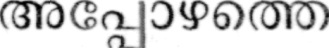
അപ്പോഴത്തെ
